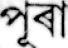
পূৰা
